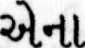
એના
